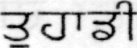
ਤੁਹਾਡੀ
